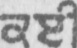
ਕਈ
